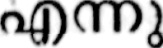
എന്നു
